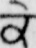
ਕੇ
